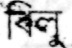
বিলু
